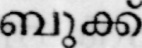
ബുക്ക്
